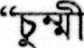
“চুম্মী
